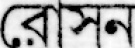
রোসন
